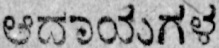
ಆದಾಯಗಳ
